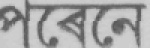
পৰেনে
